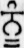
ਨੂੰ
